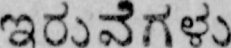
ಇರುವೆಗಳು
